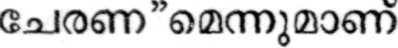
ചേരണ”മെന്നുമാണ്
